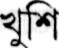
খুশি
